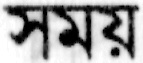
সময়
